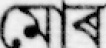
মোৰ
